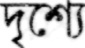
দৃশ্যে
